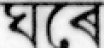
ঘৰে
